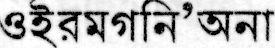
ওইরমগনি’অনা
